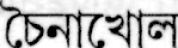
চৈনাখোল
